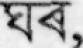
ঘৰ,
